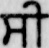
ਸੀ
